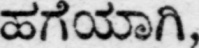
ಹಗೆಯಾಗಿ,
